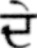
ਦੇ
